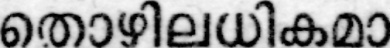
തൊഴിലധികമാ
